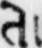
તો
